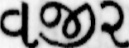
વજીર
